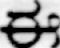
ಈ
